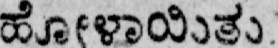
ಹೋಳಾಯಿತು.
